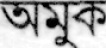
অমুক
